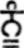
ਨੂੰ
